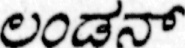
ಲಂಡನ್
